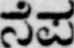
ನೆಪ
